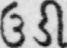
ઉડી
